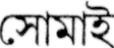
সোমাই
